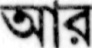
আর
